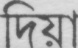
দিয়া
